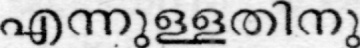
എന്നുള്ളതിനു
